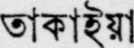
তাকাইয়া
